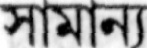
সামান্য
